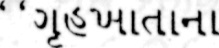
"ગૃહખાતાના
